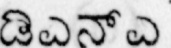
ಡಿಎನ್‌ಎ
